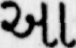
આ
